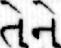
તેને
